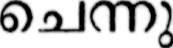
ചെന്നു
